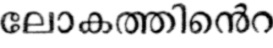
ലോകത്തിന്റെ
